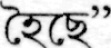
হৈছে"
